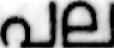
പല
